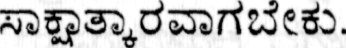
ಸಾಕ್ಷಾತ್ಕಾರವಾಗಬೇಕು.
